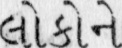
લોકોને
